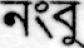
নংবু
